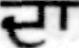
ਦਾ
